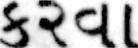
કરવા
